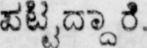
ಪಟ್ಟಿದ್ದಾರೆ.
